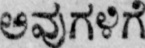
ಅವುಗಳಿಗೆ
